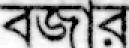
বজার
